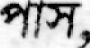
পাস,
